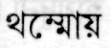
থম্মোয়
